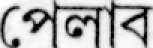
পেলাব
